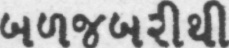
બળજબરીથી
